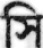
সি
